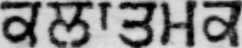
ਕਲਾਤਮਕ
